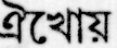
ঐখোয়
